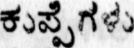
ಕುಪ್ಪೆಗಳು
